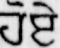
ਹੋਏ
